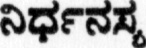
ನಿರ್ಧನಸ್ಯ
